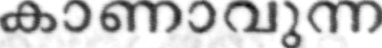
കാണാവുന്ന
